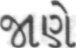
જાણે
